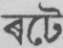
ৰটে
